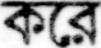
করে
